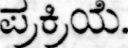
ಪ್ರಕ್ರಿಯೆ.
